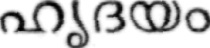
ഹൃദയം
